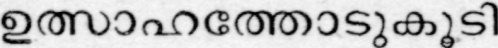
ഉത്സാഹത്തോടുകൂടി
